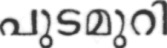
പുടമുറി
